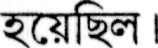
হয়েছিল।
